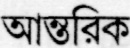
আন্তরিক
